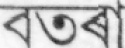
বতৰা
